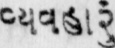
વ્યવહારું
